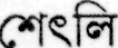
শেৎলি
